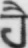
ਹੈ
